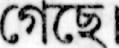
গেছে।
